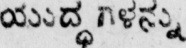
ಯುದ್ಧಗಳನ್ನು
